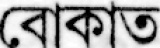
বোকাত
